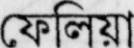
ফেলিয়া
